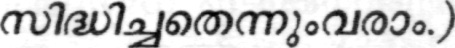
സിദ്ധിച്ചതെന്നുംവരാം.)
